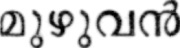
മുഴുവന്‍
